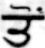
ਤੋਂ
